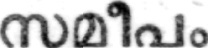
സമീപം
